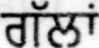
ਗੱਲਾਂ
